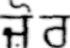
ਜ਼ੋਰ
